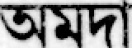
অমদা
